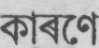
কাৰণে
